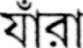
যাঁরা
